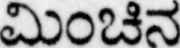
ಮಿಂಚಿನ
